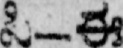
ಪಿ-ಈ
